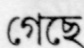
গেছে
